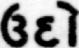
ઉદો
